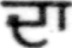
ਦਾ
